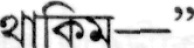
থাকিম-"
